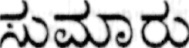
ಸುಮಾರು
